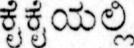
ಕೈಕೈಯಲ್ಲಿ
